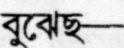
বুঝেছ–
